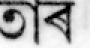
তাৰ
